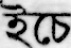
ইচে
